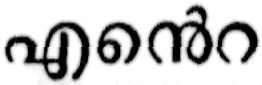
എന്റെ
